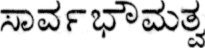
ಸಾರ್ವಭೌಮತ್ವ
